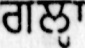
ਗਲ੍ਹਾ
